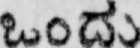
ಒಂದು
